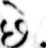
છે.
